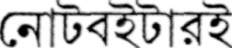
নোটবইটারই
